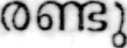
രണ്ടു
